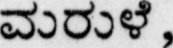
ಮರುಳೆ,
